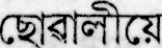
ছোৱালীয়ে
